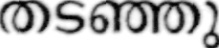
തടഞ്ഞു
